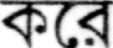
করে
